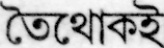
তৈথোকই
